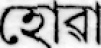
হোৱা
